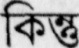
কিন্তু
